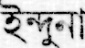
ইন্দুনা
